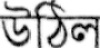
উঠিল
